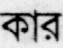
কার
